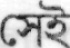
সেই
